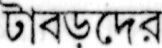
টাবড়দের
